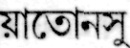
য়াতোনসু
